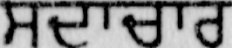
ਸਦਾਚਾਰ
